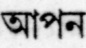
আপন
